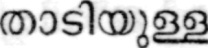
താടിയുള്ള
